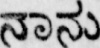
ನಾನು
